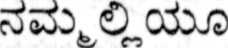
ನಮ್ಮಲ್ಲಿಯೂ
